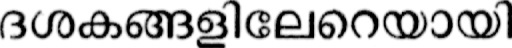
ദശകങ്ങളിലേറെയായി
